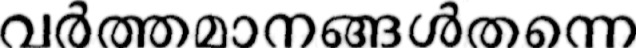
വര്‍ത്തമാനങ്ങള്‍തന്നെ
